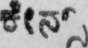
ಕೇನ್ಸ್
